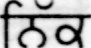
ਨਿੱਕ
